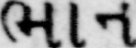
ભાન
